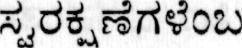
ಸ್ವರಕ್ಷಣೆಗಳೆಂಬ
